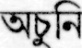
অচুনি
